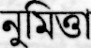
নুমিত্তা
